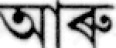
আৰু
